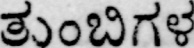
ತುಂಬಿಗಳ
